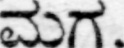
ಮಗ.
